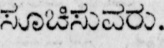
ಸೂಚಿಸುವರು.
